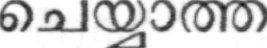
ചെയ്യാത്ത
